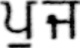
ਪੁਜ
